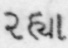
રહ્યા
